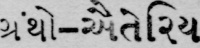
ગ્રંથ-ઐતેરિય
